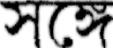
সঙ্গে
